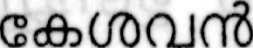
കേശവന്‍
